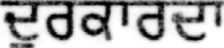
ਦੁਰਕਾਰਦਾ
